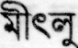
মীৎলু
